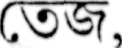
তেজ,
